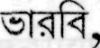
ভারবি,
